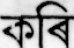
কৰি
